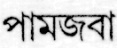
পামজবা
